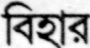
বিহার
